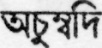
অচুম্বদি
